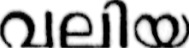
വലിയ
